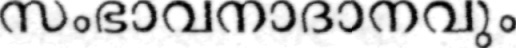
സംഭാവനാദാനവും
